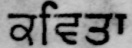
ਕਵਿਤਾ
